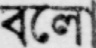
বলো
